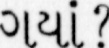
ગયાં?
